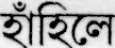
হাঁহিলে
